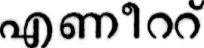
എണീററ്
